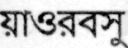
য়াওরবসু
